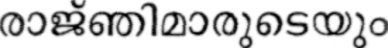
രാജ്ഞിമാരുടെയും
